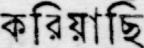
করিয়াছি
